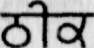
ਠੀਕ
